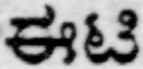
ಈಟಿ
